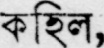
কহিল,
